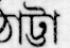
ঠাট্টা
